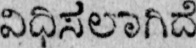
ವಿಧಿಸಲಾಗೆದೆ
